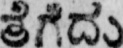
ತೆಗೆದು
